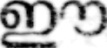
ഈ
